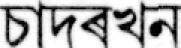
চাদৰখন
